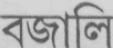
বজালি
